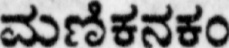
ಮಣಿಕನಕಂ
